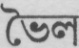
ভৈল
